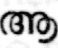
ആ
